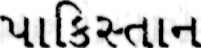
પાકિસ્તાન
